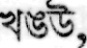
খঙউ,
